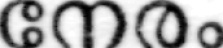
നേരം
